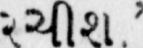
રચીશ.'
